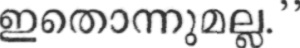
ഇതൊന്നുമല്ല."
